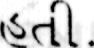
હતી.
